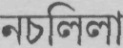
নচলিলা
